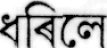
ধৰিলে
